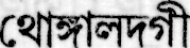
থোঙ্গালদগী
